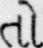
તો
